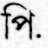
পি.
